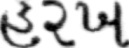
હરખ
